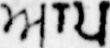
ਆਪ
